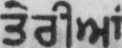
ਤੇਰੀਆਂ
